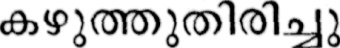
കഴുത്തുതിരിച്ചു
